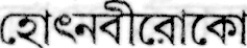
হোৎনবীরোকো
